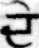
ਦੇ
